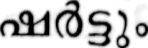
ഷര്‍ട്ടും
